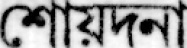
শোয়দনা
